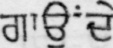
ਗਾਉਂਦੇ
